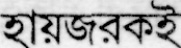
হায়জরকই
